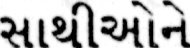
સાથીઓને
